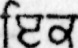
ਇਕ
